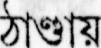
ঠাণ্ডায়
